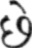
છે
